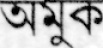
অমুক
